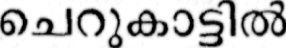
ചെറുകാട്ടില്‍
